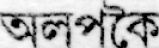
অলপকৈ
